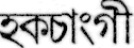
হকচাংগী
